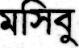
মসিবু
